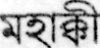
মহাক্কী
